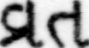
વ્રત
